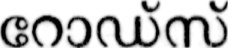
റോഡ്സ്
